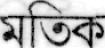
মতিক
